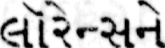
લૉરેન્સને
